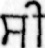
ਸੀ
